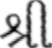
શ્રી
